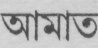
আমাত
